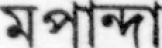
মপান্দা
